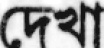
দেখা
